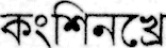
কংশিনখ্রে
